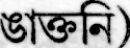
ঙাক্তনি)
